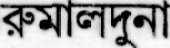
রুমালদুনা
